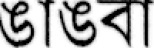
ঙাঙবা
